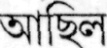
আছিল
